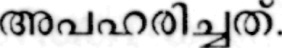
അപഹരിച്ചത്.
